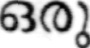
ഒരു
